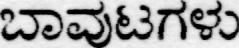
ಬಾವುಟಗಳು
